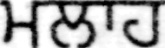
ਮਲਾਹ
